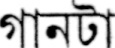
গানটা
